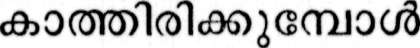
കാത്തിരിക്കുമ്പോള്‍
